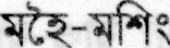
মহৈ-মশিং
